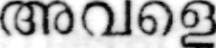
അവളെ
